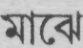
মাঝে
